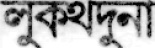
লুকথদুনা
